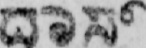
ದಾಸ್
